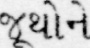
જૂથોને
